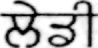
ਲੇਡੀ
